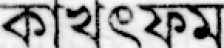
কাখৎফম
